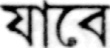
যাবে
